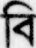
বি
